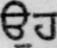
ਉਹ
